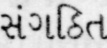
સંગઠિત
